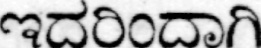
ಇದರಿಂದಾಗಿ
